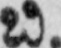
ಬಿ.
